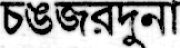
চঙজরদুনা
